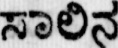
ಸಾಲಿನ
